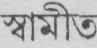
স্বামীত
